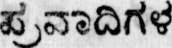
ಪ್ರವಾದಿಗಳ
